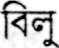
বিলু
